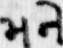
મને
